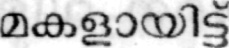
മകളായിട്ട്
